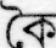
কৈ
